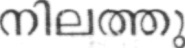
നിലത്തു
